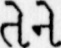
તેને
